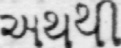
અથથી
